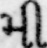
મી
